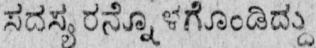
ಸದಸ್ಯರನ್ನೊಳಗೊಂಡಿದ್ದು
